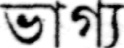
ভাগ্য
